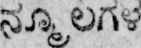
ನ್ಮೂಲಗಳ
